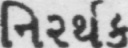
નિરર્થક
